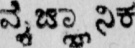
ವೈಜ್ಞಾನಿಕ
